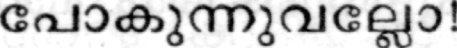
പോകുന്നുവല്ലോ!
